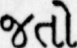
જતો
